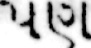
પણ
